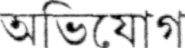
অভিযোগ
